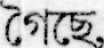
গৈছে,
